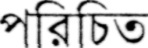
পরিচিত
